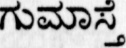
ಗುಮಾಸ್ತೆ
